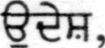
ਉਦੇਸ਼,
